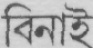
বিনাই
